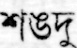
শঙদু
